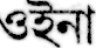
ওইনা
